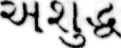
અશુદ્ધ
